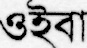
ওইবা
